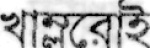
খাম্লরোই
